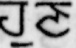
ਹੁਣ
